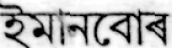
ইমানবোৰ
